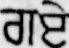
ਗਏ
